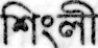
শিংলী
